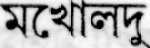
মখোলদু
